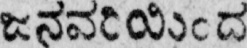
ಜನವರಿಯಿಂದ
